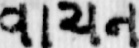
વાચન
